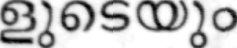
ളുടെയും
